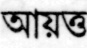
আয়ত্ত
